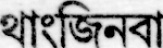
থাংজিনবা
